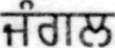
ਜੰਗਲ
